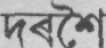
দৰশৈ
